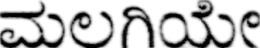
ಮಲಗಿಯೇ
